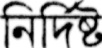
নির্দিষ্ট
